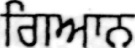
ਗਿਆਨ
